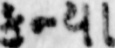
કન્યા
